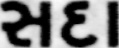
સદા
